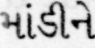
માંડીને
